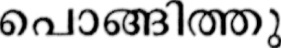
പൊങ്ങിത്തു
